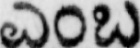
ಎಂಬ
